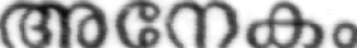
അനേകം
